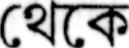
থেকে
